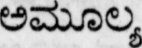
ಅಮೂಲ್ಯ
